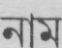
নাম
